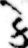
કે
